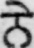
ਨੇ
